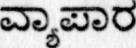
ವ್ಯಾಪಾರ
